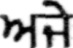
ਅਜੇ
